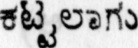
ಕಟ್ಟಲಾಗು
